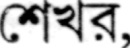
শেখর,
